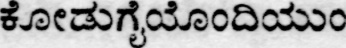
ಕೋಡುಗೈಯೊಂದಿಯುಂ
